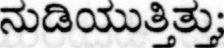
ನುಡಿಯುತ್ತಿತ್ತು;
